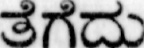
ತೆಗೆದು
